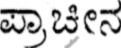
ಪ್ರಾಚೀನ
